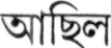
আছিল
